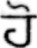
ਹੋ
